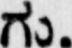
ಗು.
